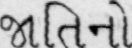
જાતિનો
